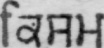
ਕਿਸਮ
